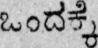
ಒಂದಕ್ಕೆ
